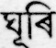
ঘূৰি
